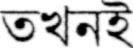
তখনই
